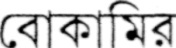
বোকামির
